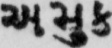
અમુક
